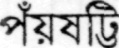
পঁয়ষট্টি
